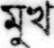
মুখ
